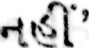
નહીં"
